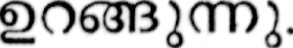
ഉറങ്ങുന്നു.
